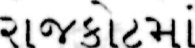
કેસસર
